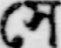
সে
